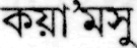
কয়া’মসু
